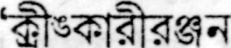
‘ক্রীঙ্কারীরঞ্জন
